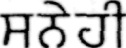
ਸਨੇਹੀ
